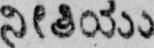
ನೀತಿಯು
